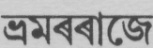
ভ্ৰমৰৰাজে
